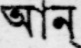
আন্
